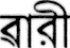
ৱারী
